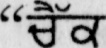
''ਚੈੱਕ
